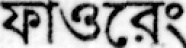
ফাওরেং
